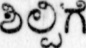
ಶಿಲ್ಪಿಗೆ
